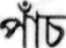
পাঁচ
